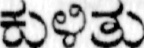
ಕುಳಿತು
